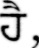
ਹੈ,
